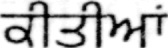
ਕੀਤੀਆਂ
